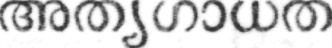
അത്യഗാധത
